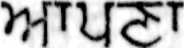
ਆਪਣਾ
